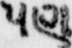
પણ
